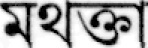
মথক্তা
